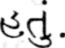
હતું.
